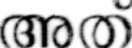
അത്
